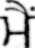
ਮੈਂ
